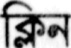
ক্লিন
